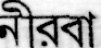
নীরবা
